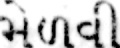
મેળવી
